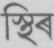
স্থিৰ
